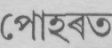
পোহৰত
